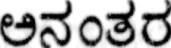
ಅನಂತರ
